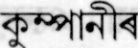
কুম্পানীৰ
